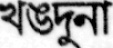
খঙদুনা
